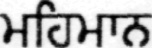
ਮਹਿਮਾਨ
